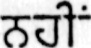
ਨਹੀਂ
